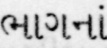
ભાગનાં
